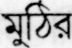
মুঠির
